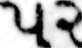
પર
